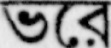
ভরে
